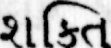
શક્તિ
